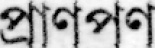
প্রাণপণ
